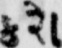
કરો
